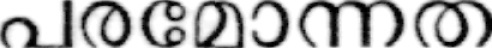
പരമോന്നത
